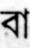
বা
